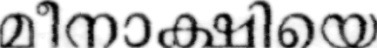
മീനാക്ഷിയെ
